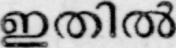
ഇതില്‍
